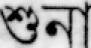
শুনা
